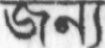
জন্য
